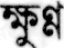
ক্ষুণ্ণ
